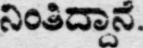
ನಿಂತಿದ್ದಾನೆ.
